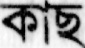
কাছ
